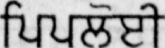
ਪਿਪਲੋਈ
